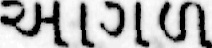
આગળ
